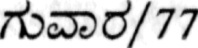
ಗುವಾರ/77
